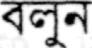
বলুন
